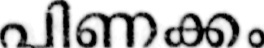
പിണക്കം
